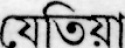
যেতিয়া
